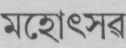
মহোৎসৱ
